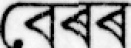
বেৰৰ
